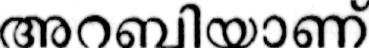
അറബിയാണ്
